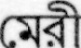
মেরী
